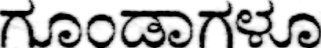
ಗೂಂಡಾಗಳೂ
